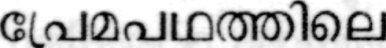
പ്രേമപഥത്തിലെ
